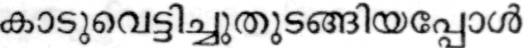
കാടുവെട്ടിച്ചുതുടങ്ങിയപ്പോള്‍
